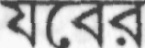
যবের
